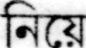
নিয়ে
